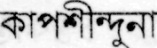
কাপশীন্দুনা
